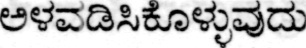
ಅಳವಡಿಸಿಕೊಳ್ಳುವುದು
